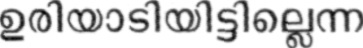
ഉരിയാടിയിട്ടില്ലെന്ന
